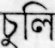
চুলি
